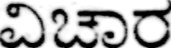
ವಿಚಾರ
